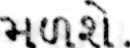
મળશે.
